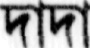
দাদা
